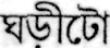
ঘড়ীটো
